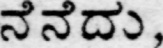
ನೆನೆದು,
